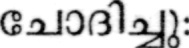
ചോദിച്ചു:
